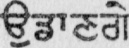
ਉਡਾਣਗੇ
